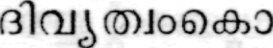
ദിവ്യത്വംകൊ
